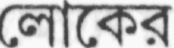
লোকের
